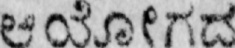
ಆಯೋಗದ
